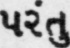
પરંતુ
